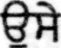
ਉਸੇ
